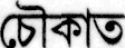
চৌকাত
